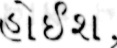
હોઈશ,
